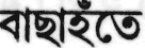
বাছাহঁতে
